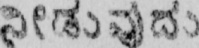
ನೀಡುವುದು
